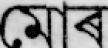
মোৰ
